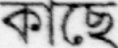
কাছে
